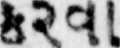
કરવા
